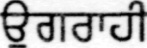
ਉਗਰਾਹੀ
